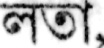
লতা,
